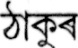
ঠাকুৰ
